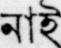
নাই
